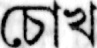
চোখ
